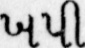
ખપી
